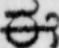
ಈ
